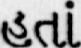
હતાં
